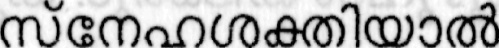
സ്നേഹശക്തിയാല്‍
